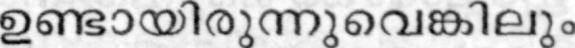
ഉണ്ടായിരുന്നുവെങ്കിലും
